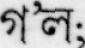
গ'ল;
